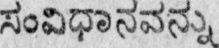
ಸಂವಿಧಾನವನ್ನು
